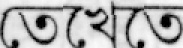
তেখেতে
